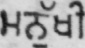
ਮਨੁੱਖੀ
